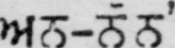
ਅਨ-ਨੋਨ'
